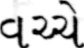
વચ્ચે
